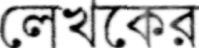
লেখকের
